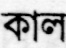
কাল
